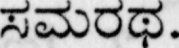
ಸಮರಥ.
